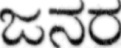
ಜನರ
